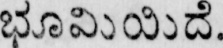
ಭೂಮಿಯಿದೆ.
